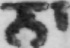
ਨਾ
